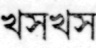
খসখস
